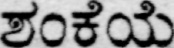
ಶಂಕೆಯೆ
